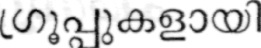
ഗ്രൂപ്പുകളായി
